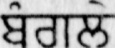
ਬੰਗਲੇ
